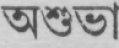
অশুভা
